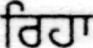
ਰਿਹਾ
